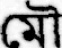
মৌ
